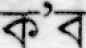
ক'ব
